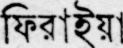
ফিরাইয়া
